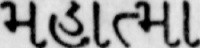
મહાત્મા
